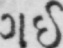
ગઈ
